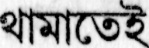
থামাতেই
